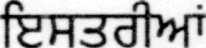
ਇਸਤਰੀਆਂ
